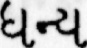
ધન્ય
